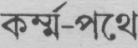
কৰ্ম্ম-পথে
